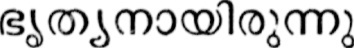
ഭൃത്യനായിരുന്നു
